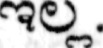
ಇಲ್ಲ.
